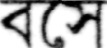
বসে
